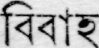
বিবাহ
